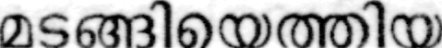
മടങ്ങിയെത്തിയ
